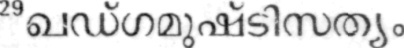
29ഖഡ്ഗമുഷ്ടിസത്യം
